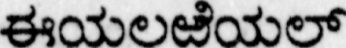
ಈಯಲಱಯಲ್
